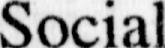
Social
